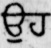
ਉਹ
